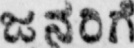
ಜನರಿಗೆ
